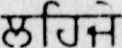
ਲਹਿਜੇ
